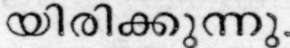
യിരിക്കുന്നു.
